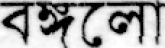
বঙ্গলো
